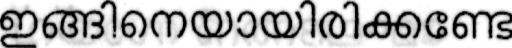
ഇങ്ങിനെയായിരിക്കണ്ടേ
